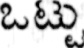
ಒಟ್ಟು
